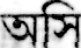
অসি
